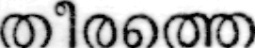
തീരത്തെ
